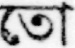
তো
